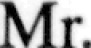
Mr.
